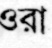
ওরা
